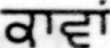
ਕਾਵਾਂ
